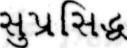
સુપ્રસિદ્ધ
